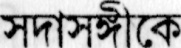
সদাসঙ্গীকে
